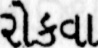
રોકવા
